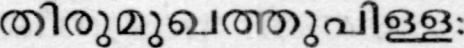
തിരുമുഖത്തുപിള്ള:
